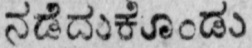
ನಡೆದುಕೊಂಡು
